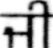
ਜੀ
